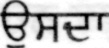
ਉਸਦਾ
